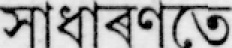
সাধাৰণতে
